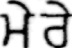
ਮੇਰੇ
